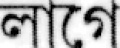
লাগে
